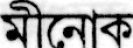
মীনোক
